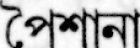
পৈশানা
